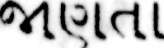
જાણતા
